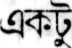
একটু
